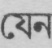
যেন
